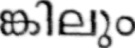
ങ്കിലും
